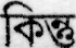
কিন্তু
